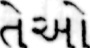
તેઓ
